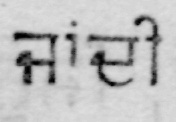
ਜਾਂਦੀ
